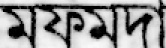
মফমদা
